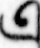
এ
